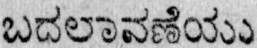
ಬದಲಾವಣೆಯು
